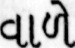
વાળે
